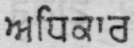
ਅਧਿਕਾਰ
